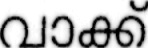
വാക്ക്
